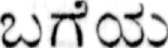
ಬಗೆಯ
